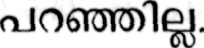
പറഞ്ഞില്ല.
